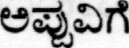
ಅಪ್ಪುವಿಗೆ
